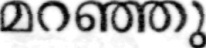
മറഞ്ഞു
